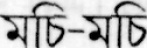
মচি-মচি
